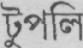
টুপলি
